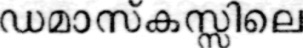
ഡമാസ്കസ്സിലെ
